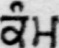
ਕੰਮ
